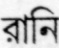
রানি
